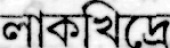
লাকখিদ্রে
